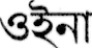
ওইনা
